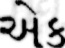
એક
